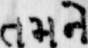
તમને
